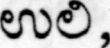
ಉಲಿ,
